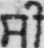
ਸੀ
